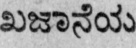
ಖಜಾನೆಯ
